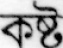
কষ্ট
